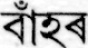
বাঁহৰ
